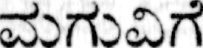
ಮಗುವಿಗೆ
